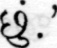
છું.'
